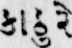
કાઠુરે
